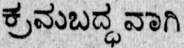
ಕ್ರಮಬದ್ಧವಾಗಿ
